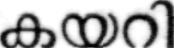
കയറി
